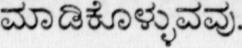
ಮಾಡಿಕೊಳ್ಳುವವು.
